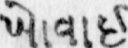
ખોવાઈ
